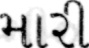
મારી
